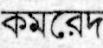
কমরেদ
